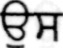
ਉਸ
